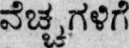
ವೆಚ್ಚಗಳಿಗೆ
